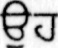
ਉਹ
